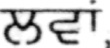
ਲਵਾਂ,
